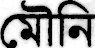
মৌনি
